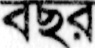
বছর
